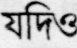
যদিও
